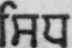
ਸਿਧ
